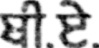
ਬੀ.ਏ.
